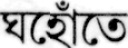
ঘহোঁতে
